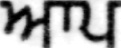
ਆਪ
